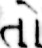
તો
